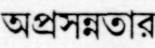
অপ্রসন্নতার
